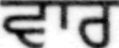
ਵਾਰ
